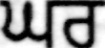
ਘਰ
